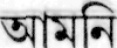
আমনি
